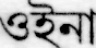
ওইনা
